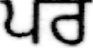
ਪਰ
